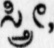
ಸ್ತ್ರೀ,
